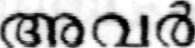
അവര്‍
